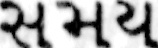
સમય
